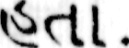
હતા.
